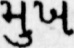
મુખ
